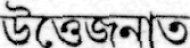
উত্তেজনাত
